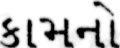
કામનો
